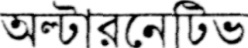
অল্টারনেটিভ
